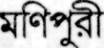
মণিপুরী
